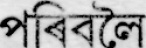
পৰিবলৈ
